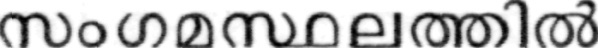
സംഗമസ്ഥലത്തില്‍
